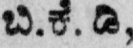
ಬಿ.ಕೆ.ಡಿ,
